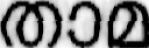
താമ
